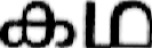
കഥ
